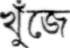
খুঁজে
